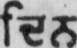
ਦਿਨ
